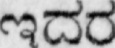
ಇದರ
